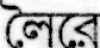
লৈরে
